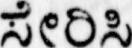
ಸೇರಿಸಿ
